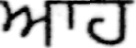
ਆਹ
